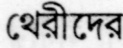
থেরীদের
